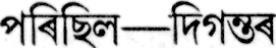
পৰিছিল-দিগন্তৰ
